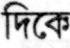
দিকে
